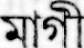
মাগী
